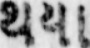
થયા
